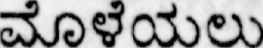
ಮೊಳೆಯಲು
